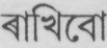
ৰাখিবো
